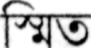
স্মিত
